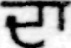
ਦਾ
